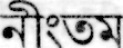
নীংতম
